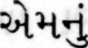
એમનું
